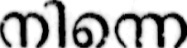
നിന്നെ
